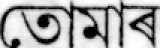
তোমাৰ
